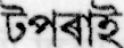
টপৰাই
